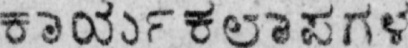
ಕಾರ್ಯಕಲಾಪಗಳ
